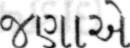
જણાએ
